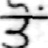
ਤੋਂ
